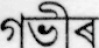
গভীৰ
